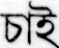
চাই
